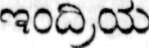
ಇಂದ್ರಿಯ
